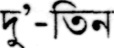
দু’-তিন
